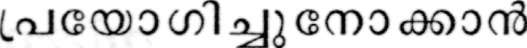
പ്രയോഗിച്ചുനോക്കാന്‍
